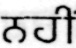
ਨਹੀਂ
